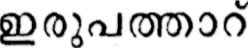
ഇരുപത്താറ്
